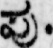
ಪು.
